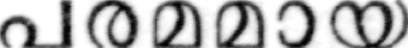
പരമമായ
